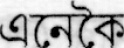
এনেকৈ
